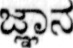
ಜ್ಞಾನ
